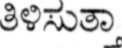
ತಿಳಿಸುತ್ತಾ
